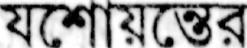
যশোয়ন্তের
